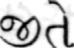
જીતે
